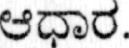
ಆಧಾರ.
